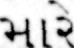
મારે
